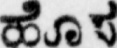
ಹೊಸ
